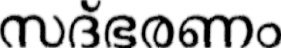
സദ്ഭരണം
